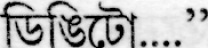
ডিঙিটো...."
